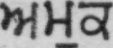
ਅਮੁਕ
